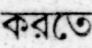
করতে
